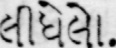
લીધેલો.
